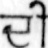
ਦੀ
